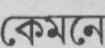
কেমনে
